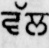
ਵੱਲ
